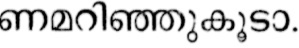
ണമറിഞ്ഞുകൂടാ.
